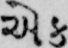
એક
